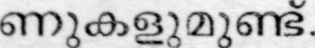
ണുകളുമുണ്ട്.
